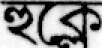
হুক্লে
